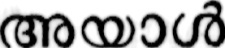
അയാള്‍
